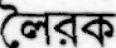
লৈরক
